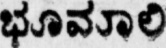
ಭೂಮಾಲಿ
